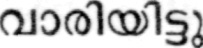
വാരിയിട്ടു
